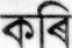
কৰি
